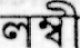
লম্বী
